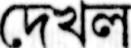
দেখল
